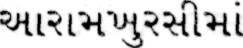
આરામખુરસીમાં
